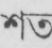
শত
